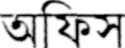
অফিস
